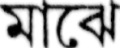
মাঝে
